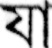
যা
